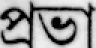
প্রভা
